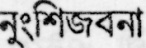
নুংশিজবনা
